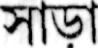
সাড়া
